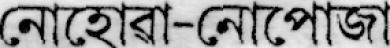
নোহোৱা-নোপোজা
